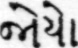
જોયો
